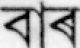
বাৰ
